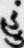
હું
